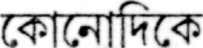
কোনোদিকে
